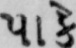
પાકે
